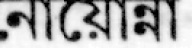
নোয়োন্না
